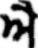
ਐ
